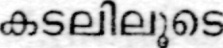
കടലിലൂടെ
